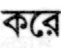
করে
